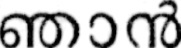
ഞാന്‍
